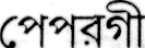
পেপরগী
